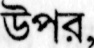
উপর,
